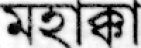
মহাক্কা
